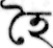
হৈ
